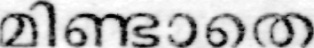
മിണ്ടാതെ
